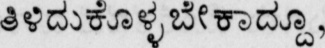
ತಿಳಿದುಕೊಳ್ಳಬೇಕಾದ್ದೂ,
